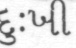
દુઃખી
